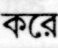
করে
